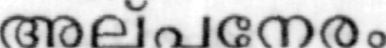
അല്പനേരം
